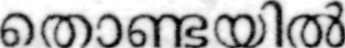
തൊണ്ടയില്‍
